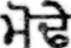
ਮੋਢੇ
